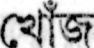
খোঁজ
